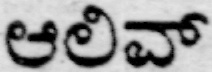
ಆಲಿವ್
